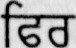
ਫਿਰ
